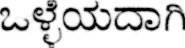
ಒಳ್ಳೆಯದಾಗಿ
